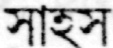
সাহস
